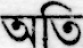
অতি
